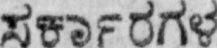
ಸರ್ಕಾರಗಳ
